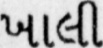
ખાલી
